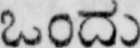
ಒಂದು
